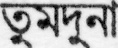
তুমদুনা
